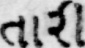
તારી
